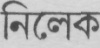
নিলেক
